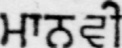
ਮਾਨਵੀ
